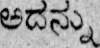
ಅದನ್ನು
